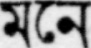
মনে
